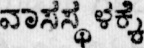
ವಾಸಸ್ಥಳಕ್ಕೆ
